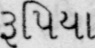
રૂપિયા
